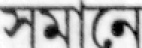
সমানে
